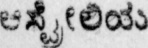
ಆಸ್ಟ್ರೇಲಿಯ
